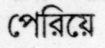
পেরিয়ে
